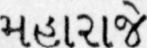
મહારાજે
